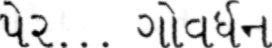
પેર...ગોવર્ધન
